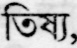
তিষ্য,
